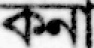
কনা
